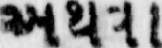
અથવા
